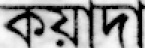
কয়াদা
